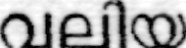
വലിയ
